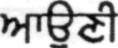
ਆਉਣੀ
